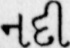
નદી
